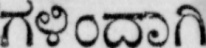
ಗಳಿಂದಾಗಿ
